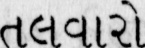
તલવારો
